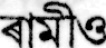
ৰামীও
